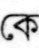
কে
